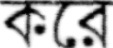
করে
